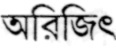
অরিজিৎ
